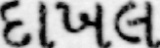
દાખલ
